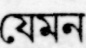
যেমন
